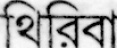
থিরিবা
